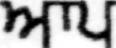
ਆਪ
